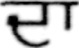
ਦਾ
